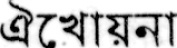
ঐখোয়না
